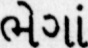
ભેગાં
